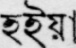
হইয়া
